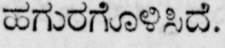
ಹಗುರಗೊಳಿಸಿದೆ.
